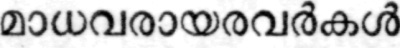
മാധവരായരവര്‍കള്‍
